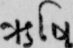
ઋષિ
